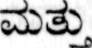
ಮತ್ತು
